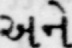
અને
